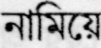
নামিয়ে
